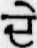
ਦੇ
